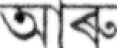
আৰু
